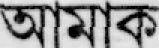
আমাক
